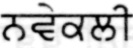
ਨਵੇਕਲੀ
